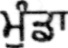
ਮੁੰਡਾ
